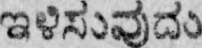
ಇಳಿಸುವುದು
